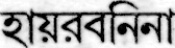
হায়রবনিনা
